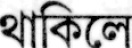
থাকিলে
